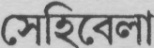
সেহিবেলা
